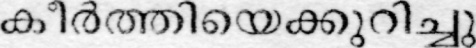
കീര്‍ത്തിയെക്കുറിച്ചു
